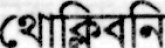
থোক্লিবনি
